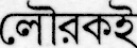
লৌরকই
